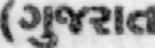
(ગુજરાત
